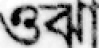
ওঝা
